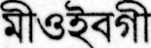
মীওইবগী
